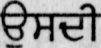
ਉਸਦੀ
